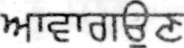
ਆਵਾਗਉਣ
